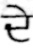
ਦੇ
